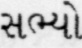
સભ્યો
